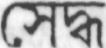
সেদ্ধ
